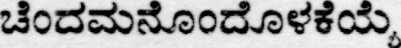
ಚೆಂದಮನೊಂದೊಳಕೆಯ್ಯೆ
